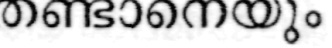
തണ്ടാനെയും
